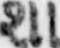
શા
